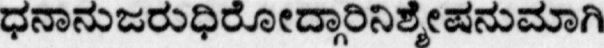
ಧನಾನುಜರುಧಿರೋದ್ಗಾರಿನಿಶ್ಶೇಷನುಮಾಗಿ
